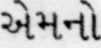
એમનો
